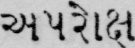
અપરોક્ષ
